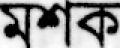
মশক
